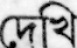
দেখি
